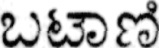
ಬಟಾಣಿ
